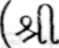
(શ્રી
